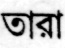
তারা
